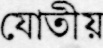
যোতীয়
